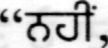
''ਨਹੀਂ,
